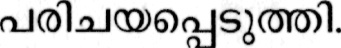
പരിചയപ്പെടുത്തി.
